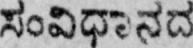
ಸಂವಿಧಾನದ
